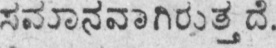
ಸಮಾನವಾಗಿರುತ್ತದೆ.
